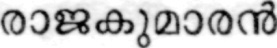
രാജകുമാരന്‍
